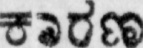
ಕಾರಣ
